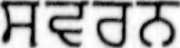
ਸਵਰਨ
